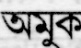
অমুক
